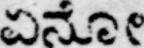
ಏನೋ
